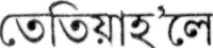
তেতিয়াহ'লে
